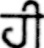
ਹੀ
